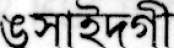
ঙসাইদগী
